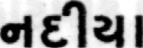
નદીયા
